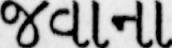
જવાના
